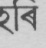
হৰি
